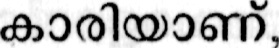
കാരിയാണ്,
